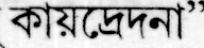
কায়দ্রেদনা”
